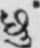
છું
